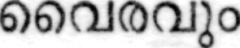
വൈരവും
